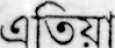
এতিয়া
